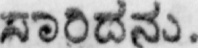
ಸಾರಿದನು.
